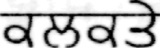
ਕਲਕਤੇ
